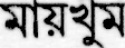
মায়খুম
